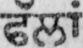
ਫੱਲਾਂ
